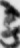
કે
